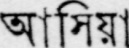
আসিয়া
